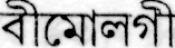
বীমোলগী
